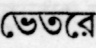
ভেতরে
